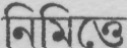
নিমিত্তে
